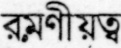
রমণীয়ত্ব
